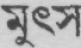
মুৎস
